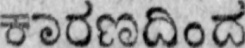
ಕಾರಣದಿಂದ
